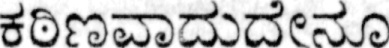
ಕಠಿಣವಾದುದೇನೂ
